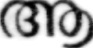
ആ
